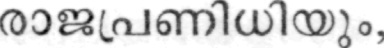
രാജപ്രണിധിയും,
